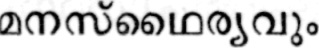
മനസ്ഥൈര്യവും
